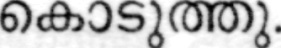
കൊടുത്തു.
